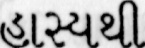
હાસ્યથી
